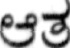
ಆತ
